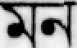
মন
